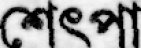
শেৎপা
